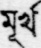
মূর্খ
